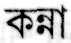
কন্না
